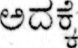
ಅದಕ್ಕೆ
